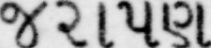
જરાપણ
